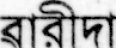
ৱারীদা
